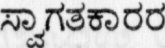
ಸ್ವಾಗತಕಾರರ
